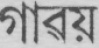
গাৱয়
